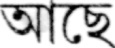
আছে
